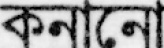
কনানো
